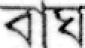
বাঘ
